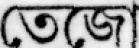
তেজো
